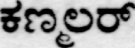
ಕಣ್ಮಲರ್
